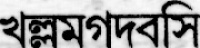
খল্লমগদবসি
